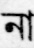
না
